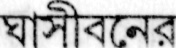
ঘাসীবনের
